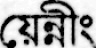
য়েন্নীং
